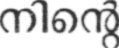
നിന്റെ
